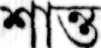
শান্ত
